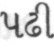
પઢી
